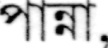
পান্না,
